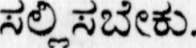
ಸಲ್ಲಿಸಬೇಕು.
